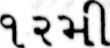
૧૨મી
